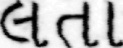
લતા
